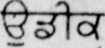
ਉਡੀਕ
